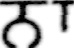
ਨਾ
